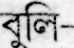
বুলি-
